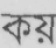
কয়
